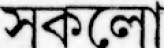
সকলো
